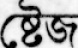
ষ্টেজ
